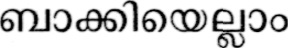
ബാക്കിയെല്ലാം
